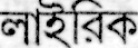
লাইরিক
